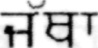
ਜੱਥਾ
